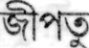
জীপতু
